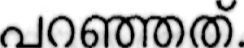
പറഞ്ഞത്.
